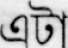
এটা
